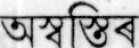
অস্বস্তিৰ
